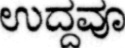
ಉದ್ದವೂ
